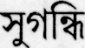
সুগন্ধি
